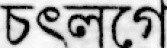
চৎলগে
